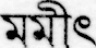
মমীৎ
